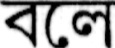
বলে
